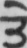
ਤੇ
